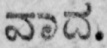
ವಾದ.
